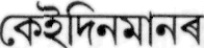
কেইদিনমানৰ
